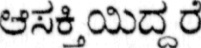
ಆಸಕ್ತಿಯಿದ್ದರೆ
